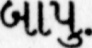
બાપુ.
